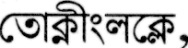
তোক্নীংলক্লে,
